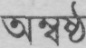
অম্বষ্ঠ
